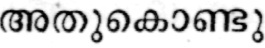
അതുകൊണ്ടു
